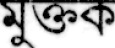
মুক্তক
